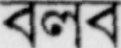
বলব
